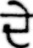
ਦੇ
